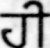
ਹੀ
